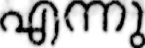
എന്നു
